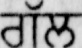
ਗੱਲ
